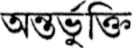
অন্তর্ভুক্তি
